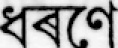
ধৰণে
